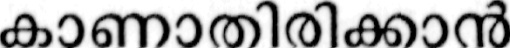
കാണാതിരിക്കാന്‍
